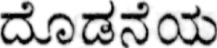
ದೊಡನೆಯ
